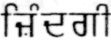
ਜ਼ਿੰਦਗੀ
